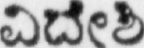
ವಿದೇಶಿ
